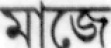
মাজে
